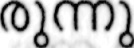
രുന്നു
